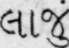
લાજું
